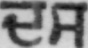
ਦਸ
